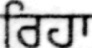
ਰਿਹਾ
